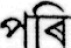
পৰি
